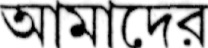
আমাদের
